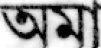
অমা
